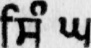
ਸਿੰਘ
